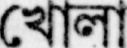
খোলা
